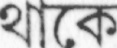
থাকে
